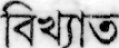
বিখ্যাত
